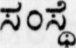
ಸಂಸ್ಥೆ
